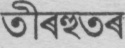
তীৰহুতৰ
